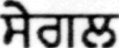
ਸੇਗਲ
